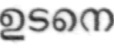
ഉടനെ
